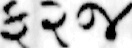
ફરજ
